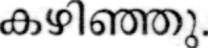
കഴിഞ്ഞു.
